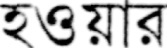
হওয়ার
